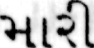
મારી
